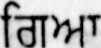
ਗਿਆ
